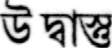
উদ্বাস্তু
